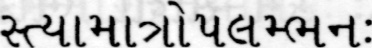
સ્ત્યામાત્રોપલમ્ભનઃ
